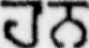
ਹਨ
